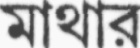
মাথার
